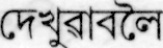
দেখুৱাবলৈ
